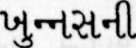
ખુન્નસની
